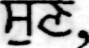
ਸੁਣ,
